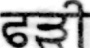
ਫੜੀ
